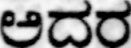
ಅದರ
